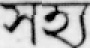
সহ্য
